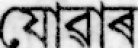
যোৱাৰ
